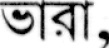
ভারা,
